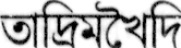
তাদ্রিমখৈদি
